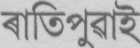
ৰাতিপুৱাই
